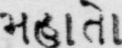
મહાતો
